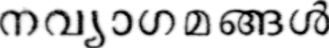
നവ്യാഗമങ്ങള്‍
